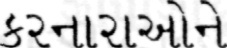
કરનારાઓને
